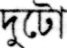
দুটো
